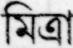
মিত্রা
